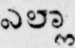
ಎಲ್ಲಾ
